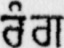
ਰੰਗ
